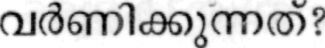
വര്‍ണിക്കുന്നത്?
